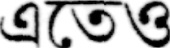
এতেও
